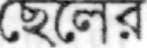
ছেলের
